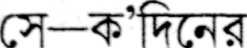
সে–ক’দিনের
